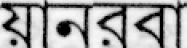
য়ানরবা
